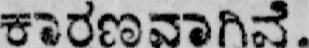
ಕಾರಣವಾಗಿವೆ.
